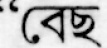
"বেছ
